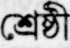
শ্রেষ্ঠী
